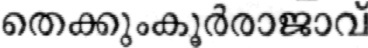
തെക്കുംകൂര്‍രാജാവ്
